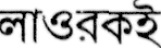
লাওরকই
